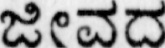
ಜೀವದ
